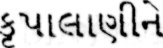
કૃપાલાણીને
